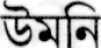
উমনি
